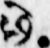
છે.
